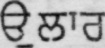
ਉਲਾਰ
